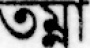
তম্না
